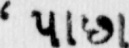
'પાછા
